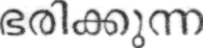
ഭരിക്കുന്ന
